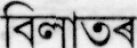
বিলাতৰ
